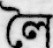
লৈ
